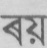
ৰয়
